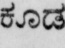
ಕೂಡ
